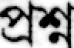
প্রশ্ন
